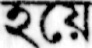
হয়ে
